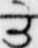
ਤੇ
